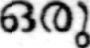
ഒരു
